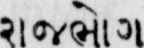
રાજભોગ
